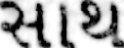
સાથ
